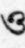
ও
